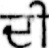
ਦੀ
